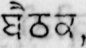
ਬੈਠਕ,
